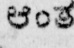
ಆಂತ
